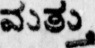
ಮತ್ತು
